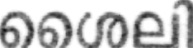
ശൈലി
